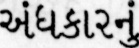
અંધકારનું
